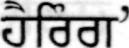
ਹੈਰਿੰਗ'
